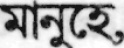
মানুহে,
